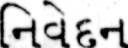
નિવેદન
